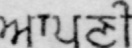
ਆਪਣੀ
